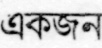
একজন
